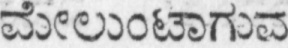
ಮೇಲುಂಟಾಗುವ
